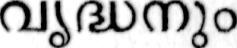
വൃദ്ധനും
